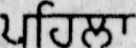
ਪਹਿਲਾ
